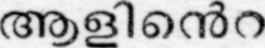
ആളിന്റെ
